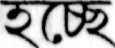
হচ্ছে
